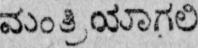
ಮಂತ್ರಿಯಾಗಲಿ
